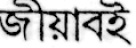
জীয়াবই
